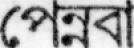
পেন্নবা
